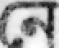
নে
